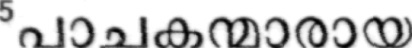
5പാചകന്മാരായ
